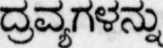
ದ್ರವ್ಯಗಳನ್ನು
